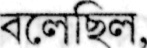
বলেছিল,
